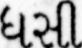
ધસી
